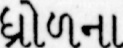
ધ્રોળના
